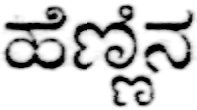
ಹೆಣ್ಣೆನ
